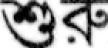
শুরু
